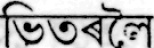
ভিতৰলৈ
